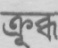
ক্ৰুব্ধ
